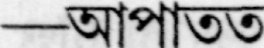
-আপাতত
